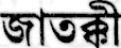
জাতক্কী
